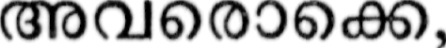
അവരൊക്കെ,
